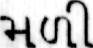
મળી
